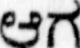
ಆಗ
